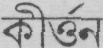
কীৰ্ত্তন
